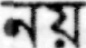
নয়
